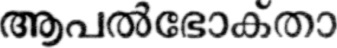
ആപല്‍ഭോക്താ
